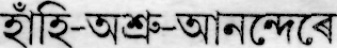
হাঁহি-অশ্ৰু-আনন্দেৰে
